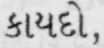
કાયદો,
